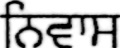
ਨਿਵਾਸ
